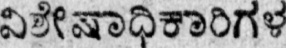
ವಿಶೇಷಾಧಿಕಾರಿಗಳ
